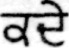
ਕਦੇ
